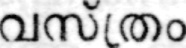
വസ്ത്രം
